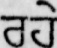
ਰਹੇ
